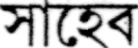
সাহেব
